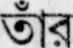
তাঁর
